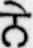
ਨੇ
